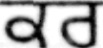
ਕਰ
